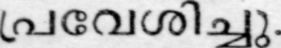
പ്രവേശിച്ചു.
